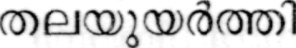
തലയുയര്‍ത്തി
